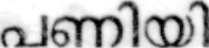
പണിയി
